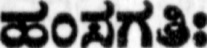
ಹ೦ಸಗತಿಃ
